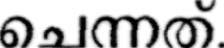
ചെന്നത്.
